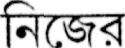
নিজের
